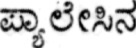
ಪ್ಯಾಲೇಸಿನ
